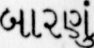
બારણું
